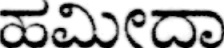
ಹಮೀದಾ
